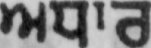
ਅਧਾਰ
